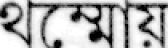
থম্মোয়
